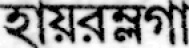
হায়রম্লগা
